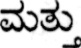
ಮತ್ತು
